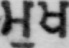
ਮੁਖ
